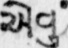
એવું
